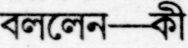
বললেন–কী
